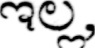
ಇಲ್ಲ,
